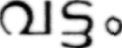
വട്ടം
